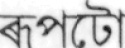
ৰূপটো
